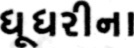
ધૂધરીના
